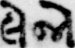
લેજો
